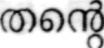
തന്റെ
